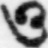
ও
